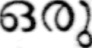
ഒരു
